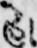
હો
